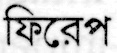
ফিরেপ
